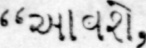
"આવશે,
